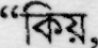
"কিয়,
